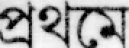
প্রথমে
